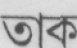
তাক
